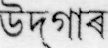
উদ্‌গাৰ
